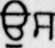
ਉਸ
